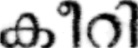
കീറി
